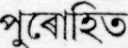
পুৰোহিত
